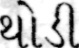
થોડી
